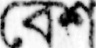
বেশ
